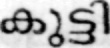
കുട്ടി
